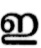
ഇ
